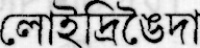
লোইদ্রিঙৈদা
